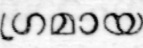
ഗ്രമായ
